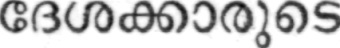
ദേശക്കാരുടെ
